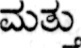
ಮತ್ತು
